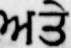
ਅਤੇ
